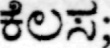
ಕೆಲಸ;
